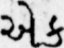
એક
